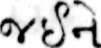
જઈને
